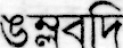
ঙম্লবদি
